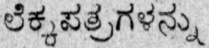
ಲೆಕ್ಕಪತ್ರಗಳನ್ನು
